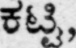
ಕಟ್ಟಿ,
